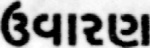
ઉવારણ
